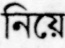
নিয়ে
